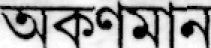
অকণমান
